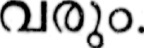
വരും.
